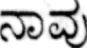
ನಾವು
